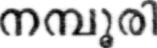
നമ്പൂരി
